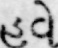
હવે
